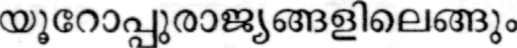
യൂറോപ്പുരാജ്യങ്ങളിലെങ്ങും
